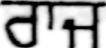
ਰਾਜ
